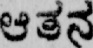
ಆತನ
